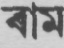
ৰাম
